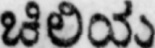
ಚಿಲಿಯ
